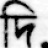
দি.
